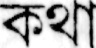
কথা
